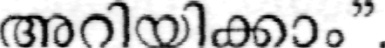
അറിയിക്കാം".
